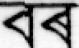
বৰ
